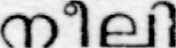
നീലി
